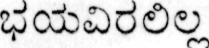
ಭಯವಿರಲಿಲ್ಲ
